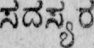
ಸದಸ್ಯರ
